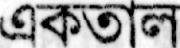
একতাল
